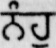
ਨੰਹੁ
